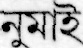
নুমাই
